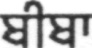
ਬੀਬਾ
